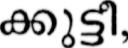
ക്കുട്ടീ,
